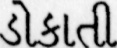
ડોકાતી
